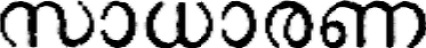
സാധാരണ
